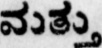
ಮತ್ತು
